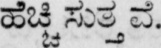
ಹೆಚ್ಚಿಸುತ್ತವೆ.
